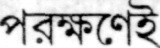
পরক্ষণেই
